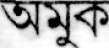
অমুক
